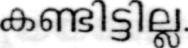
കണ്ടിട്ടില്ല.
